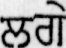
ਲਗੇ
